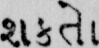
શકતો
